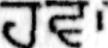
ਹਵਾ
